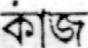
কাজ
